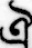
ঐ
